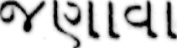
જણાવા
